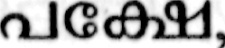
പക്ഷേ,
